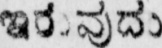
ಇರುವುದು
